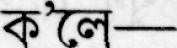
ক'লে-
